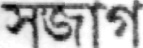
সজাগ
